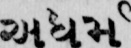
અધર્મ
